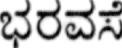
ಭರವಸೆ
